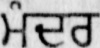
ਮੰਦਰ
